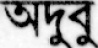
অদুবু
